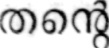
തന്റെ
